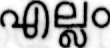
എല്ലം
